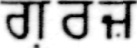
ਗਰਜ਼
